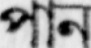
পান
